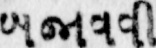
બજાવવી
